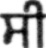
ਸੀ
